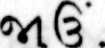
જાઉં.
